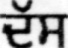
ਦੱਸ
